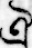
ঐ
